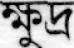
ক্ষুদ্র
